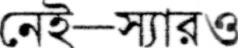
নেই–স্যারও
